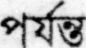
পর্যন্ত
